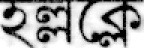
হল্লক্লে
